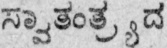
ಸ್ವಾತಂತ್ರ್ಯದ
